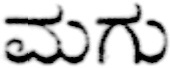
ಮಗು
